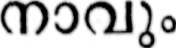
നാവും
